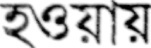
হওয়ায়
